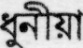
ধুনীয়া
